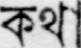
কথা
